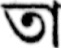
তা
